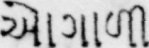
ઓગાળી
